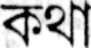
কথা
